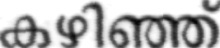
കഴിഞ്ഞ്
